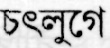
চৎলুগে
